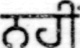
ਨਹੀਂ
